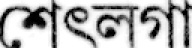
শেৎলগা
